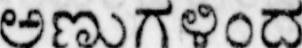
ಅಣುಗಳಿಂದ
